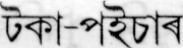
টকা-পইচাৰ
